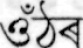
ওঁঠৰ
